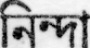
নিন্দা
